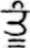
ਤੂੰ
